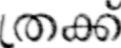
ത്രക്ക്
